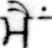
ਮੈਂ
